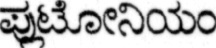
ಪ್ಲುಟೋನಿಯಂ
